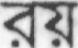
রয়
